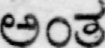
ಅಂತ
